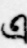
এ
